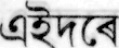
এইদৰে
